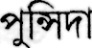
পুন্সিদা
